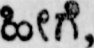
ಹೀಗೆ,
